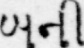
બની
